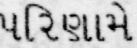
પરિણામે
